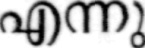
എന്നു
